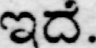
ಇದೆ.
